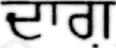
ਦਾਗ਼
